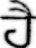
ਹੈ
